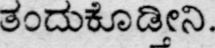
ತಂದುಕೊಡ್ತೀನಿ.
